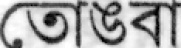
তোঙবা
